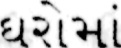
ઘરોમાં
